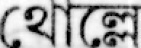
থোল্লে
